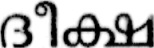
ദീക്ഷ
